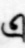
এ
